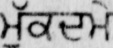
ਮੁੱਕਦਮੇ
